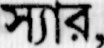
স্যার,
